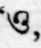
‘ও,
